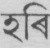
হৰি
